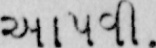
આપવી.
